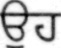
ਉਹ
